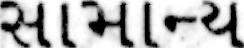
સામાન્ય
